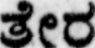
ತೇರ
